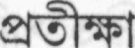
প্রতীক্ষা
